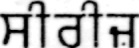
ਸੀਰੀਜ਼
